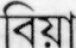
বিয়া
